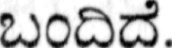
ಬಂದಿದೆ.
